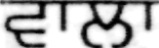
ਵਾਲਾ
